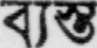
ব্যস্ত
